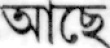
আছে
